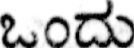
ಒಂದು
